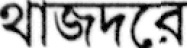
থাজদরে
